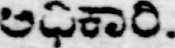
ಅಧಿಕಾರಿ.
